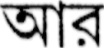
আর
